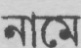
নামে
